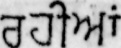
ਰਹੀਆਂ
